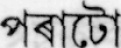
পৰাটো
